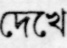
দেখে
